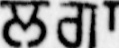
ਲਗਾ
